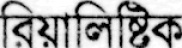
রিয়ালিষ্টিক
